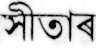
সীতাৰ
